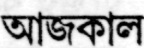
আজকাল
